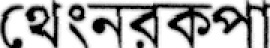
থেংনরকপা
